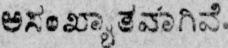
ಅಸಂಖ್ಯಾತವಾಗಿವೆ.
